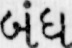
બંધ
